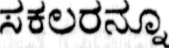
ಸಕಲರನ್ನೂ
